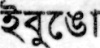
ইবুঙো
